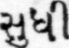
સુધી
